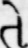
તે
